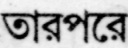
তারপরে
